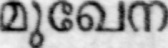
മുഖേന
